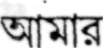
আমার
